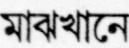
মাঝখানে
